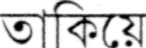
তাকিয়ে
